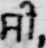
ਸੀ,
